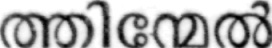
ത്തിന്മേല്‍
